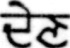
ਦੇਣ
